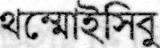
থম্মোইসিবু
